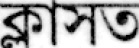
ক্লাসত
